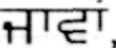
ਜਾਵਾਂ,
